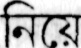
নিয়ে
